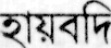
হায়বদি
